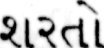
શરતો
